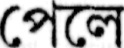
পেলে
